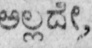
ಅಲ್ಲದೇ,
